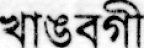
খাঙবগী
